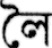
লৈ
